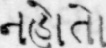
નહોતો
